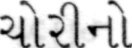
ચોરીનો
